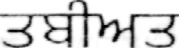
ਤਬੀਅਤ
